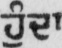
ਹੁੰਦਾ
